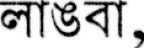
লাঙবা,
